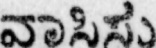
ವಾಸಿಸು
